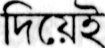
দিয়েই
